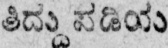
ತಿದ್ದುಪಡಿಯ
